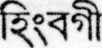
হিংবগী
